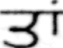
ਤਾਂ
